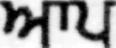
ਆਪ
